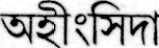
অহীংসিদা
